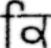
ਕਿ
